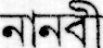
নানবী
